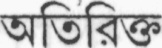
অতিরিক্ত
